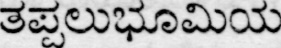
ತಪ್ಪಲುಭೂಮಿಯ
